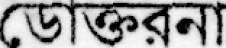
ডোক্তরনা
